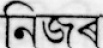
নিজৰ
